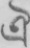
ঐ
